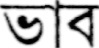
ভাব
